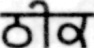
ਠੀਕ
